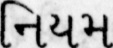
નિયમ
